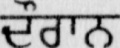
ਦੌਰਾਨ
